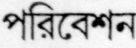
পরিবেশন
